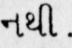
નથી.
